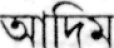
আদিম
